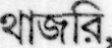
থাজরি,
